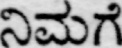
ನಿಮಗೆ
